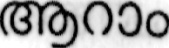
ആറാം
